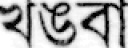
খঙবা
